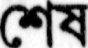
শেষ
